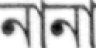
নানা
